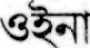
ওইনা
